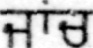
ਜਾਂਚ
